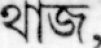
থাজ,
